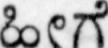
ಹೀಗೆ
